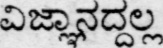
ವಿಜ್ಞಾನದ್ದಲ್ಲ
